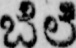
ಬೆಲೆ
